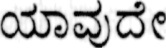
ಯಾವುದೇ
